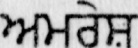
ਅਮਰੇਸ਼
